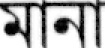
মানা
